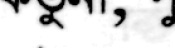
য়েকতুনা,
